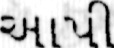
આપી
